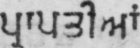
ਪ੍ਰਾਪਤੀਆਂ
